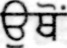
ਉਥੋਂ
